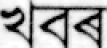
খবৰ
